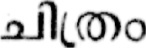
ചിത്രം
